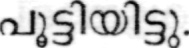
പൂട്ടിയിട്ടു.
